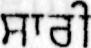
ਸਾਰੀ
